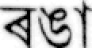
ৰঙা
